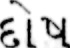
દોષ
